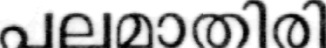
പലമാതിരി
